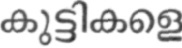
കുട്ടികളെ
